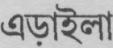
এড়াইলা
